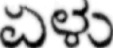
ಏಳು
